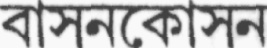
বাসনকোসন
